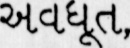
અવધૂત,
